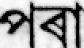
পৰা
